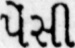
પેંસી
